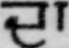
ਦਾ
